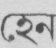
হেন
